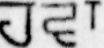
ਹਵਾ
